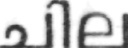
ചില
